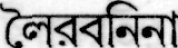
লৈরবনিনা
